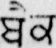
ਬੈਕ
